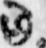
છે.
